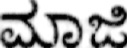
ಮಾಜಿ
